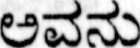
ಅವನು
